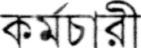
কর্মচারী
